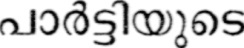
പാര്‍ട്ടിയുടെ
